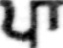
ਪਾ
